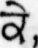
ਕੇ,
